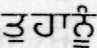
ਤੁਹਾਨੂੰ
